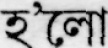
হ'লো
